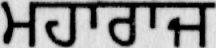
ਮਹਾਰਾਜ
